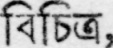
বিচিত্র,
